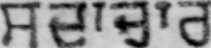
ਸਦਾਚਾਰ
